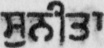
ਸੁਨੀਤਾ
